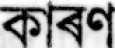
কাৰণ
